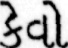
કેવો
